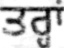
ਤਰ੍ਹਾਂ
